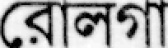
রোলগা
